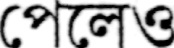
পেলেও
